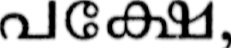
പക്ഷേ,
